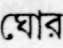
ঘোর
